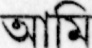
আমি
